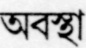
অবস্থা
